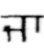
ਜਾ
